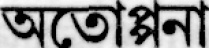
অতোপ্পনা
